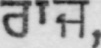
ਰਾਜ,
